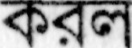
করল
